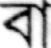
বা
